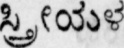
ಸ್ತ್ರೀಯಳ
